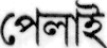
পেলাই
